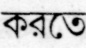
করতে
